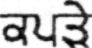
ਕਪੜੇ
